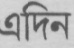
এদিন
